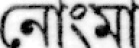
নোংমা
